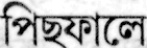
পিছফালে
